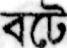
বটে
